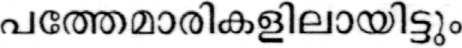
പത്തേമാരികളിലായിട്ടും
